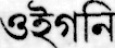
ওইগনি
